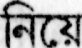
নিয়ে
